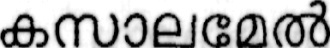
കസാലമേല്‍
